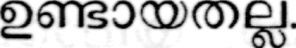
ഉണ്ടായതല്ല.
